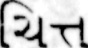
ચિત્ત
